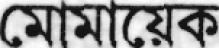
মোমায়েক
